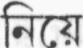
নিয়ে
